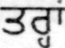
ਤਰ੍ਹਾਂ
